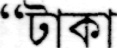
“টাকা
